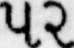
પર
